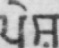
ਪੇਸ਼
